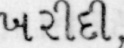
ખરીદી,
